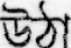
উঠা
